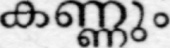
കണ്ണും
